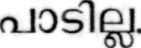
പാടില്ല.
